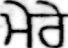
ਮੇਰੇ
